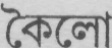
কৈলো
